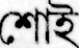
শোই
